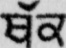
ਥੱਕ
